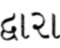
દ્વારા
